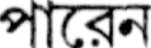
পারেন
